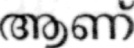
ആണ്
